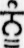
ਨੂੰ
